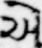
એ
